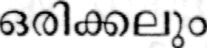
ഒരിക്കലും
